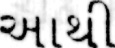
આથી
